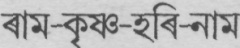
ৰাম-কৃষ্ণ-হৰি-নাম
